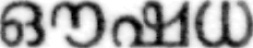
ഔഷധ
